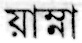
য়াম্না
